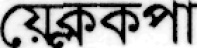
য়েক্লকপা
